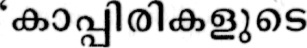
‘കാപ്പിരികളുടെ
